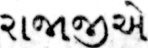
રાજાજીએ
